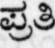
ಪ್ರತಿ
